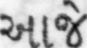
આજે
